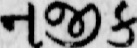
નજીક
